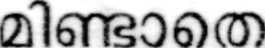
മിണ്ടാതെ
